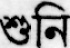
শুনি
